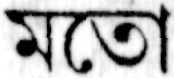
মতো
